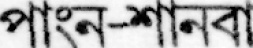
পাংন-শানবা
